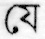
যে
